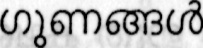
ഗുണങ്ങള്‍
